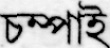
চম্পাই
